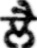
ਲੈ
